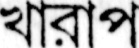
খারাপ
